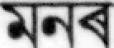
মনৰ
